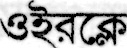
ওইরক্লে
